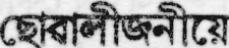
ছোৱালীজনীয়ে
